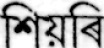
শিয়ৰি
